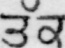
ਤੱਕ
